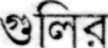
গুলির
